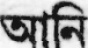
আনি
